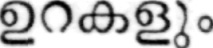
ഉറകളും
